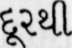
દૂરથી
